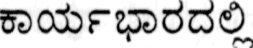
ಕಾರ್ಯಭಾರದಲ್ಲಿ
